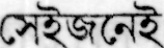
সেইজনেই
